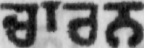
ਚਾਰਨ
